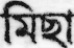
মিছা
